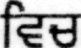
ਵਿਚ
